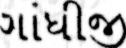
ગાંધીજી
